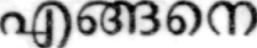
എങ്ങനെ
